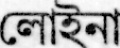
লোইনা
